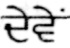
ਦੇਵੇਂ
